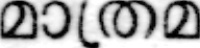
മാത്രമ
